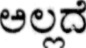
ಅಲ್ಲದೆ
